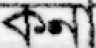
কনা
